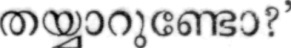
തയ്യാറുണ്ടോ?'
